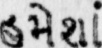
હમેંશા
